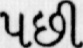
પછી
